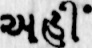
અહીં
